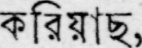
করিয়াছ,
